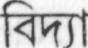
বিদ্যা
